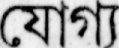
যোগ্য
